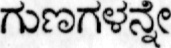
ಗುಣಗಳನ್ನೇ
